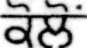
ਕੋਲੋਂ
